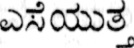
ಎಸೆಯುತ್ತ
